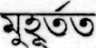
মুহূর্তত
